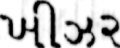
ખીઝર
